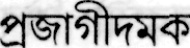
প্রজাগীদমক
